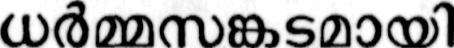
ധര്‍മ്മസങ്കടമായി
